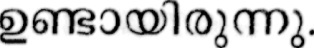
ഉണ്ടായിരുന്നു.
